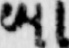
બા
